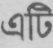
এটি
